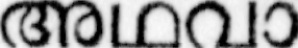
അഥവാ
